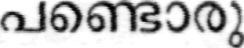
പണ്ടൊരു
